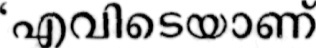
‘എവിടെയാണ്
